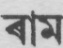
ৰাম
